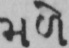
મળે
